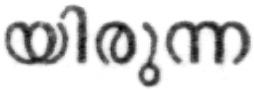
യിരുന്ന
